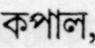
কপাল,
